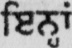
ਇਨ੍ਹਾਂ
